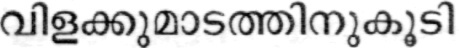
വിളക്കുമാടത്തിനുകൂടി
